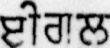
ਈਗਲ
